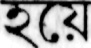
হয়ে
